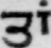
ਤਾਂ
